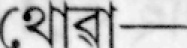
থোৱা-
